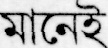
মানেই
